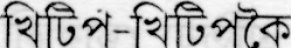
খিটিপ-খিটিপকৈ
